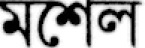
মশেল
